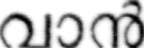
വാന്‍
